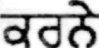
ਕਰਨੇ
